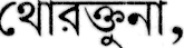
থোরক্তুনা,
